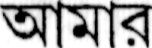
আমার
